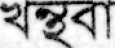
খন্থবা
